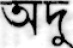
অদু
